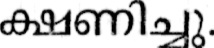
ക്ഷണിച്ചു.
